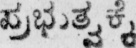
ಪ್ರಭುತ್ವಕ್ಕೆ
